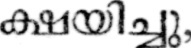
ക്ഷയിച്ചു,
